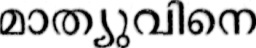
മാത്യുവിനെ
